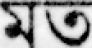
মত
